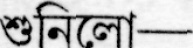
শুনিলো-
